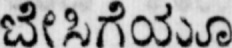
ಬೇಸಿಗೆಯೂ
